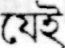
যেই
